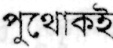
পুথোকই
